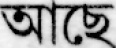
আছে
